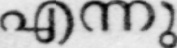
എന്നു
